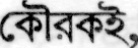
কৌরকই,
